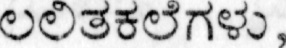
ಲಲಿತಕಲೆಗಳು,
